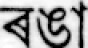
ৰঙা
